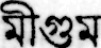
মীগুম
